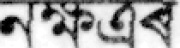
নক্ষত্রৰ
